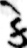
કે
